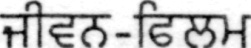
ਜੀਵਨ-ਫਿਲਮ
